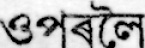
ওপৰলৈ
